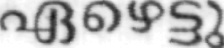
ഏഴെട്ടു
